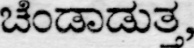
ಚೆಂಡಾಡುತ್ತ,
